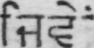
ਜਿਵੇਂ
